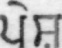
ਪੇਸ਼
